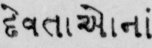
દેવતાઓનાં
